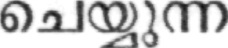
ചെയ്യുന്ന
